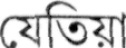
যেতিয়া
